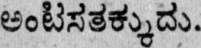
ಅಂಟಿಸತಕ್ಕುದು.
